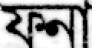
ফনা
